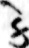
કે
